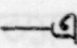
–এ
